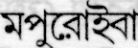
মপুরোইবা
